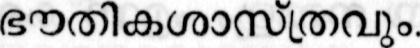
ഭൌതികശാസ്ത്രവും.
